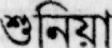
শুনিয়া
